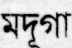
মদূগা
